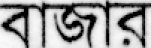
বাজার
